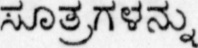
ಸೂತ್ರಗಳನ್ನು
